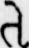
તે
